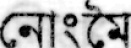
নোংমৈ
